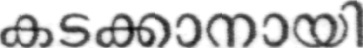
കടക്കാനായി
